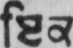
ਇਕ
